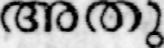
അതു
